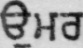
ਉਮਰ
